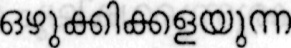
ഒഴുക്കിക്കളയുന്ന
